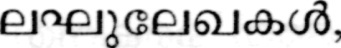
ലഘുലേഖകള്‍,
